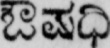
ಔಷಧಿ
